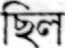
ছিল
